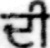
ਦੀ
